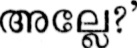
അല്ലേ?’
